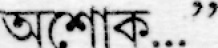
অশোক..."
